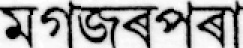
মগজৰপৰা
